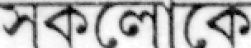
সকলোকে
